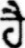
ਹੈ
